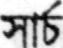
সার্চ
